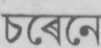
চৰেনে
